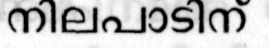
നിലപാടിന്
